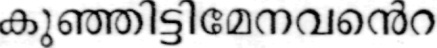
കുഞ്ഞിട്ടിമേനവന്റെ
